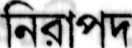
নিরাপদ
